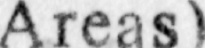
Areas)
